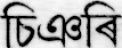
চিঞৰি
